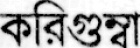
করিগুম্বা
